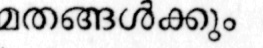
മതങ്ങള്‍ക്കും
